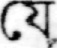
যে
